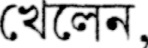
খেলেন,
